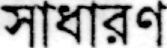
সাধারণ
